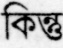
কিন্তু
